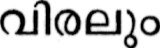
വിരലും
